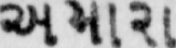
અમારા
